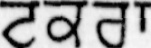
ਟਕਰਾ
